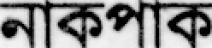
নাকপাক
